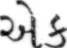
એક
